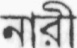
নারী
